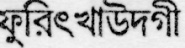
ফুরিৎখাউদগী
